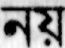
নয়
